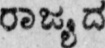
ರಾಜ್ಯದ
